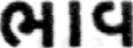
ભાવ
